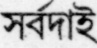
সর্বদাই
